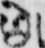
છો
